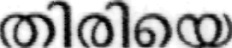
തിരിയെ
